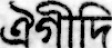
ঐগীদি
